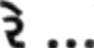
રે....
